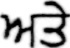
ਅਤੇ
